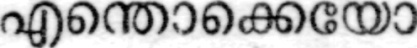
എന്തൊക്കെയോ
